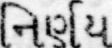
નિર્ણય
